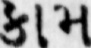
કામ
